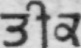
ਤੀਕ
